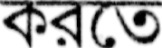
করতে
